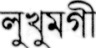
লুখুমগী
